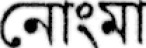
নোংমা
